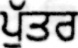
ਪੁੱਤਰ
